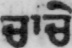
ਚਾਚੇ
